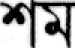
শম
